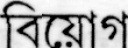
বিয়োগ
